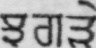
ਝਗੜੇ
